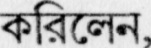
করিলেন,
